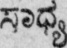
ಸಾಧ್ಯ
